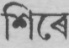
শিৰে
